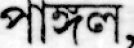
পাঙ্গল,
